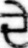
ਦੇ
